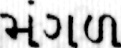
મંગળ
